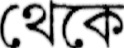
থেকে
